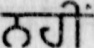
ਨਹੀਂ
